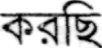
করছি
